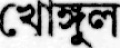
খোঙ্গুল
